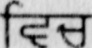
ਵਿਚ
